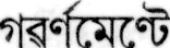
গৱর্ণমেন্টে
